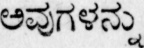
ಅವುಗಳನ್ನು
